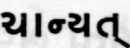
ચાન્યત્
